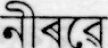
নীৰৱে
